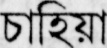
চাহিয়া
